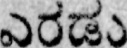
ಎರಡು
